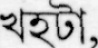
খহটা,
